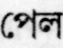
পেল
